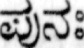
ಪುನಃ
